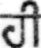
ਹੀ
